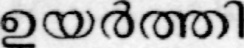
ഉയര്‍ത്തി
